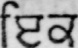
ਇਕ
